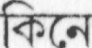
কিনে
